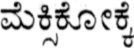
ಮೆಕ್ಸಿಕೋಕ್ಕೆ
